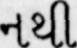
નથી
